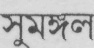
সুমঙ্গল
